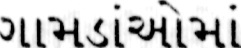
ગામડાંઓમાં
